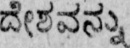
ದೇಶವನ್ನು
